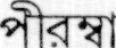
পীরম্বা
